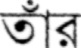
তাঁর
